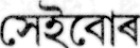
সেইবোৰ
